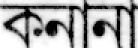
কনানা
